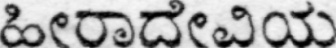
ಹೀರಾದೇವಿಯ
